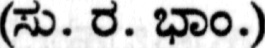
(ಸು.ರ.ಭಾಂ.)
